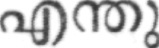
എന്തു
